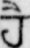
ਹੈ
